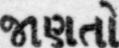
જાણતો
